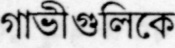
গাভীগুলিকে
